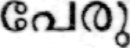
പേരു
